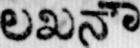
ಲಖನೌ
